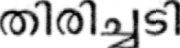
തിരിച്ചടി
